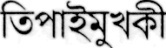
তিপাইমুখকী
